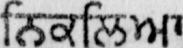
ਨਿਕਲਿਆ
